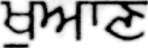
ਖੁਆਣ
